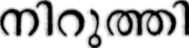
നിറുത്തി
